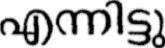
എന്നിട്ടു
